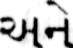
અને
